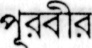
পূরবীর
